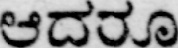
ಆದರೂ
